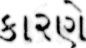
કારણે
